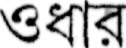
ওধার
